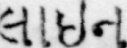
લાઈન
